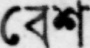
বেশ
